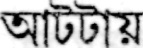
আটটায়
